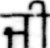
ਜੀ
